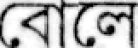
বোলে
